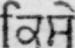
ਕਿਸੇ
